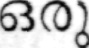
ഒരു
